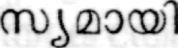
സ്യമായി
